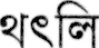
থৎলি
